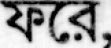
ফরে,
